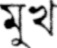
মুখ
